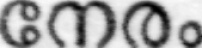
നേരം
